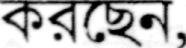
করছেন,
